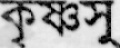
কৃষ্ণসু
